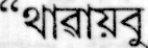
“থাৱায়বু
